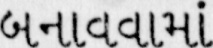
બનાવવામાં
